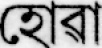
হোৱা
